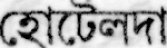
হোটেলদা
